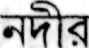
নদীর
